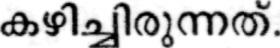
കഴിച്ചിരുന്നത്.
